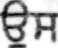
ਉਸ
